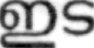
ഇട
